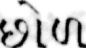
છોળ
